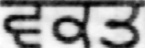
ਵਕਤ
